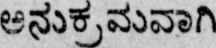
ಅನುಕ್ರಮವಾಗಿ
